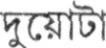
দুয়োটা
